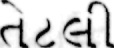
તેટલી
